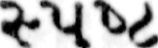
સ્પષ્ટ
